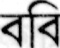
ববি
